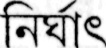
নির্ঘাত্
